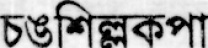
চঙশিল্লকপা
